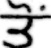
ਤੋਂ
